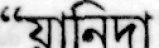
“য়ানিদা
